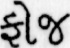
ફોજ
